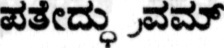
ಪತೇದ್ಧ್ರುವಮ್
